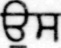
ਉਸ
